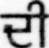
ਦੀ
